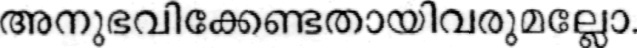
അനുഭവിക്കേണ്ടതായിവരുമല്ലോ.
